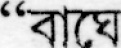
"বাঘে
